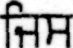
ਜਿਸ
